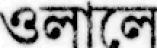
ওলালে
